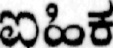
ಐಹಿಕ
